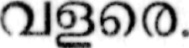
വളരെ.
